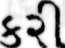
કરી
